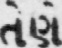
તેણે
